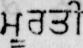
ਮੂਰਤੀ
